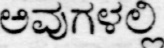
ಅವುಗಳಲ್ಲಿ
